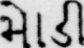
મોડી
